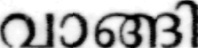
വാങ്ങി
